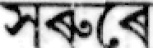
সৰুৰে
